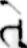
તે
